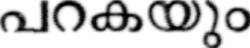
പറകയും
